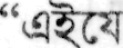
"এইযে
